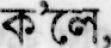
ক'লে,
